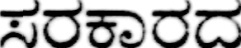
ಸರಕಾರದ
